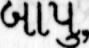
બાપુ,
